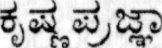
ಕೃಷ್ಣಪ್ರಜ್ಞಾ
